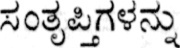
ಸಂತೃಪ್ತಿಗಳನ್ನು
